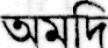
অমদি
